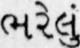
ભરેલું
